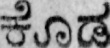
ಕೊಡ
